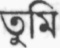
তুমি
